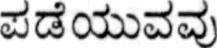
ಪಡೆಯುವವು
